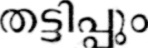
തട്ടിപ്പും
